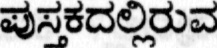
ಪುಸ್ತಕದಲ್ಲಿರುವ
